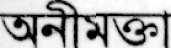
অনীমক্তা
